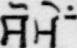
ਸੋਮੇਂ
